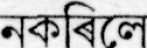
নকৰিলে
